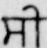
ਸੀ
